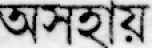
অসহায়
